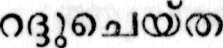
റദ്ദുചെയ്ത
